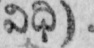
ವಿಧಿ).
